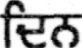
ਦਿਨ
